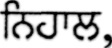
ਨਿਹਾਲ,
